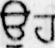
ਉਹ
